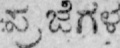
ಪ್ರಜೆಗಳ
